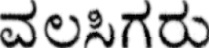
ವಲಸಿಗರು
